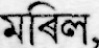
মৰিল,
